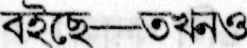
বইছে–তখনও
